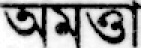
অমত্তা
